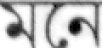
মনে
